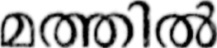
മത്തില്‍
